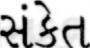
સંકેત
